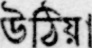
উঠিয়া
